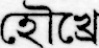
হৌখ্রে
